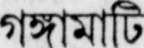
গঙ্গামাটি
